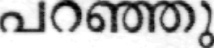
പറഞ്ഞു
